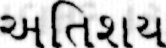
અતિશય
